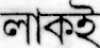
লাকই
